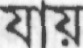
যায়
